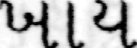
ખાય
